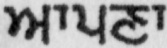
ਆਪਣਾ
